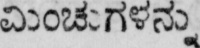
ಮಿಂಚುಗಳನ್ನು
